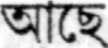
আছে
